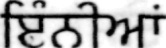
ਇੰਨੀਆਂ
